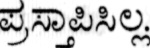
ಪ್ರಸ್ತಾಪಿಸಿಲ್ಲ.
